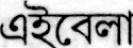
এইবেলা
